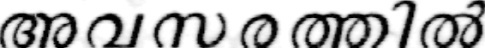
അവസരത്തില്‍
